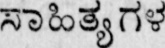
ಸಾಹಿತ್ಯಗಳ
